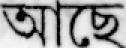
আছে
